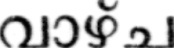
വാഴ്ച
